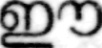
ഈ
